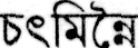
চৎমিন্নৈ
